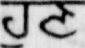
ਹੁਣ
